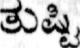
ತುಷ್ಟಿ
